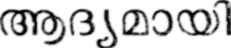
ആദ്യമായി
